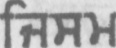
ਜਿਸਮ
